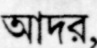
আদর,
